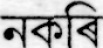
নকৰি
